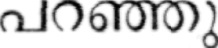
പറഞ്ഞു
